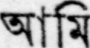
আমি
